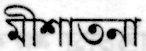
মীশাতনা
